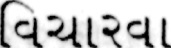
વિચારવા
